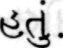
હતું.
